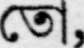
তো,
